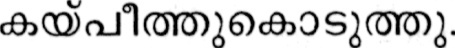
കയ്പീത്തുകൊടുത്തു.
